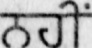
ਨਹੀਂ
